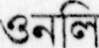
ওনলি
